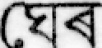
ঘেৰ
